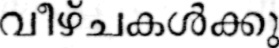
വീഴ്ചകള്‍ക്കു
